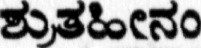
ಶ್ರುತಹೀನಂ
